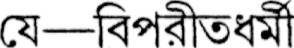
যে-বিপরীতধর্মী
